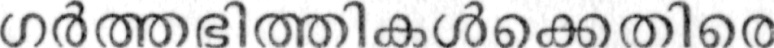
ഗര്‍ത്തഭിത്തികള്‍ക്കെതിരെ
